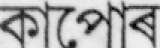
কাপোৰ
